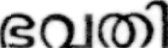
ഭവതി
